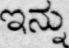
ಇನ್ನು
